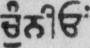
ਚੁੰਨੀਓਂ
